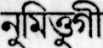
নুমিত্তুগী
